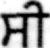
ਸੀ
